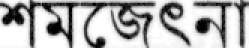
শমজেৎনা
